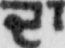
ਦਾ
